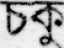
চকু
